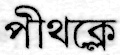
পীথক্লে
